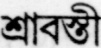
শ্রাবস্তী
